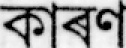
কাৰণ
